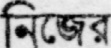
নিজের
